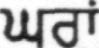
ਘਰਾਂ
